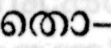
തൊ-
